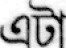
এটা
